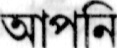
আপনি
